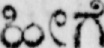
ಹೀಗೆ
